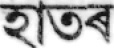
হাতৰ
